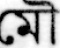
মৌ
